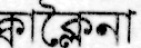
ক্বাক্লৈনা
